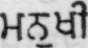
ਮਨੁਖੀ
